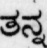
ತನ್ನ
